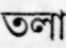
তলা
